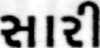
સારી
